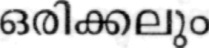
ഒരിക്കലും
